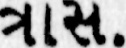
ત્રાસ.
